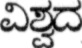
ವಿಶ್ವದ
